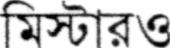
মিস্টারও
